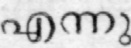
എന്നു
